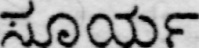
ಸೂರ್ಯ
